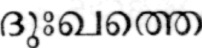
ദുഃഖത്തെ
